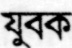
যুবক
